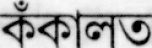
কঁকালত
